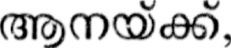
ആനയ്ക്ക്,
